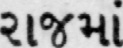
રાજમાં
